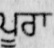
ਪੂਰਾ
